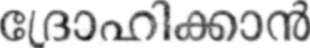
ദ്രോഹിക്കാന്‍
